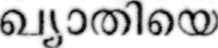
ഖ്യാതിയെ
